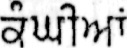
ਕੰਘੀਆਂ
